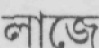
লাজে
